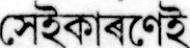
সেইকাৰণেই
